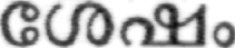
ശേഷം
